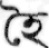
হৈ
